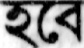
হবে
